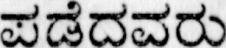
ಪಡೆದವರು
